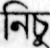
নিচু
